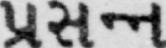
પ્રસન્ન
